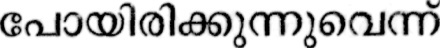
പോയിരിക്കുന്നുവെന്ന്
